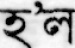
হ'ল
